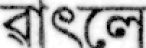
ৱাৎলে
